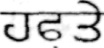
ਹਫ਼ਤੇ
